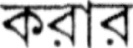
করার
